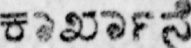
ಕಾರ್ಖಾನೆ
